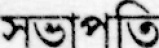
সভাপতি
